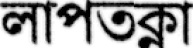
লাপতক্না
